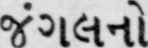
જંગલનો
